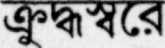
ক্রুদ্ধস্বরে
